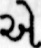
એ
